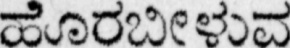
ಹೊರಬೀಳುವ
